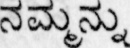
ನಮ್ಮನ್ನು
